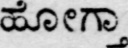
ಹೋಗ್ತಾ
